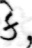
કે,
